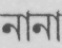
নানা
